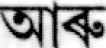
আৰু
